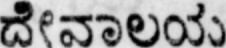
ದೇವಾಲಯ
